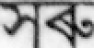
সৰু
